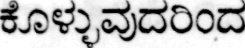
ಕೊಳ್ಳುವುದರಿಂದ
